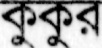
কুকুর
